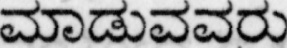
ಮಾಡುವವರು
